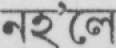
নহ'লে
